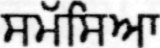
ਸਮੱਸਿਆ
